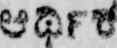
ಆರ್ಥಿಕ
